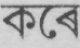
কৰে
